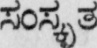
ಸಂಸ್ಕೃತ
